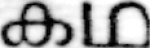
കഥ
